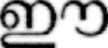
ഈ
